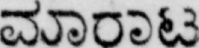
ಮಾರಾಟ
